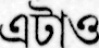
এটাও
